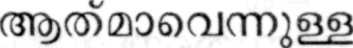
ആത്മാവെന്നുള്ള
